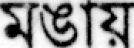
মঙায়
